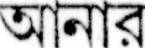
আনার
